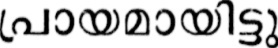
പ്രായമായിട്ടു
